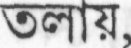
তলায়,
